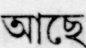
আছে
